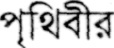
পৃথিবীর
